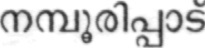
നമ്പൂരിപ്പാട്
